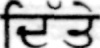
ਦਿੱਤੇ
